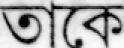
তাকে
